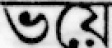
ভয়ে
